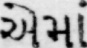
એમાં
